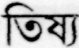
তিষ্য
